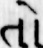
તો
